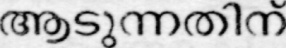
ആടുന്നതിന്
